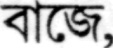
বাজে,
